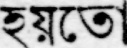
হয়তো
